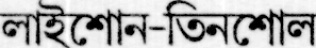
লাইশোন-তিনশোল
